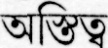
অস্তিত্ব
